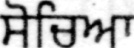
ਸੋਚਿਆ
